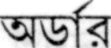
অর্ডার
